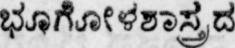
ಭೂಗೋಳಶಾಸ್ತ್ರದ
